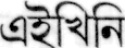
এইখিনি
